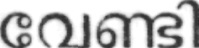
വേണ്ടി
